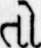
તો
